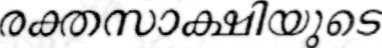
രക്തസാക്ഷിയുടെ
